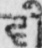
ਵੀ
